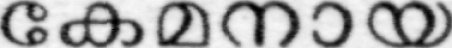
കേമനായ
